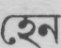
হেন
